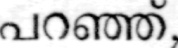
പറഞ്ഞ്,
